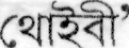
থোইবী’
